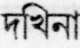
দখিনা
